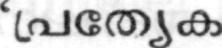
'പ്രത്യേക
